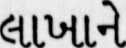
લાખાને
